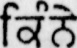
ਕਿੰਨੇ
